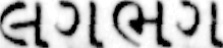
લગભગ
